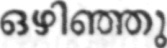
ഒഴിഞ്ഞു
